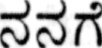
ನನಗೆ
